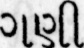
ગણી
